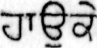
ਹਾਉਕੇ
